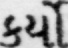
કર્યો
